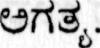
ಅಗತ್ಯ.
